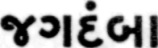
જગદંબા
